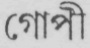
গোপী
